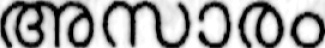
അസാരം
